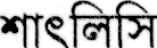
শাৎলিসি
